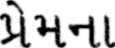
પ્રેમના
